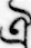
ঐ
